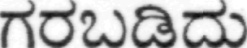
ಗರಬಡಿದು
